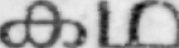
കഥ
